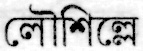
লৌশিল্লে
